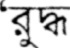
‘রুদ্ধ
